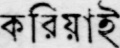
করিয়াই
